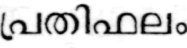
പ്രതിഫലം
